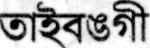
তাইবঙগী
